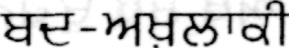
ਬਦ-ਅਖ਼ਲਾਕੀ
